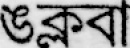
ঙক্লবা
